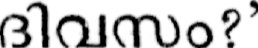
ദിവസം?’
